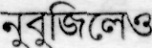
নুবুজিলেও
